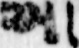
આ
